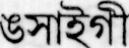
ঙসাইগী
